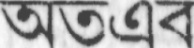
অতএব
